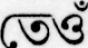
তেওঁ
